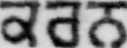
ਕਰਨ
